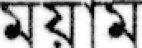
ময়াম
